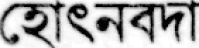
হোৎনবদা
